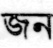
জন
